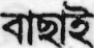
বাছাই
